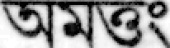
অমত্তং
